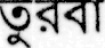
তুরবা
